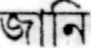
জানি
